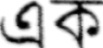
এক
